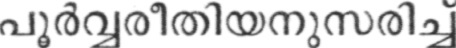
പൂര്‍വ്വരീതിയനുസരിച്ച്
